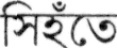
সিহঁতে
